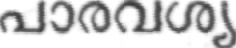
പാരവശ്യ
